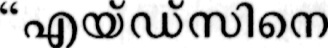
എയ്‌ഡ്‌സിനെ
